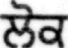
ਲੋਕ
